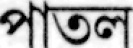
পাতল
